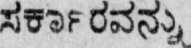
ಸರ್ಕಾರವನ್ನು
